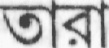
তারা
